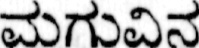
ಮಗುವಿನ
